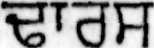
ਢਾਰਸ
